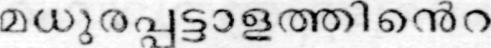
മധുരപ്പട്ടാളത്തിന്റെ
